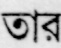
তার
